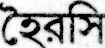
হৈরসি
